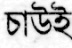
চাউই
